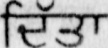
ਦਿੱਤਾ
